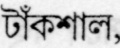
টাঁকশাল,
